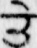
ਤੇ
